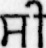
ਸੀ
